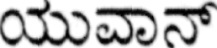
ಯುವಾನ್
